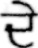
ਦੇ
